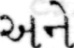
અને
